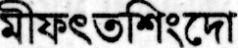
মীফৎতশিংদো
